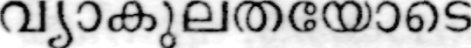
വ്യാകുലതയോടെ
